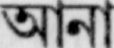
আনা
